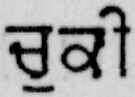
ਚੁਕੀ
